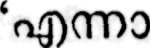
‘എന്നാ
